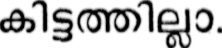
കിട്ടത്തില്ലാ.
